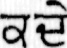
ਕਦੇ
